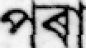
পৰা
